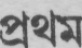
প্ৰথম
